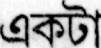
একটা
